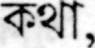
কথা,
